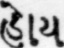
હોય
